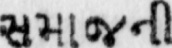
સમાજની
